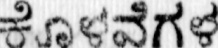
ಕೊಳವೆಗಳ
